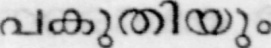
പകുതിയും
